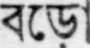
বড়ো
